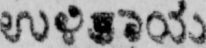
ಉಳಿತಾಯ
